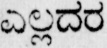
ಎಲ್ಲದರ
